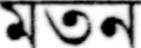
মতন
